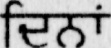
ਦਿਨਾਂ
